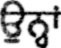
ਉਨ੍ਹਾਂ
